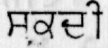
ਸਕਦੀ
